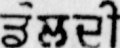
ਡੋਲਦੀ
